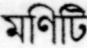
মণিটি
